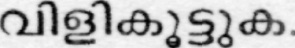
വിളികൂട്ടുക.
